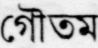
গৌতম
